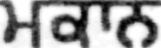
ਮਕਾਨ
